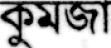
কুমজা
